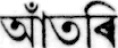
আঁতৰি
